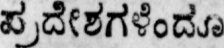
ಪ್ರದೇಶಗಳೆಂದೂ
